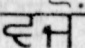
ਵਜੋਂ
